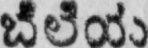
ಬೆಲೆಯ
